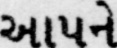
આપને
